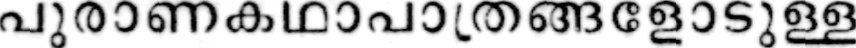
പുരാണകഥാപാത്രങ്ങളോടുള്ള
